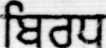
ਬਿਰਧ
